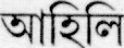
আহিলি
